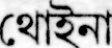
থোইনা
